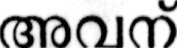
അവന്
